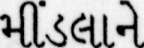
મીંડલાને
